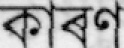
কাৰণ
